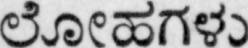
ಲೋಹಗಳು
